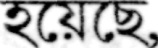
হয়েছে,
